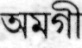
অমগী
